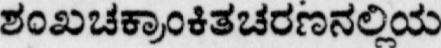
ಶಂಖಚಕ್ರಾಂಕಿತಚರಣನಲ್ಲಿಯ
